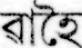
ৱাহৈ
